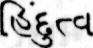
હિંદુત્વ
